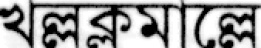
খল্লক্লমাল্লে
